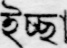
ইচ্ছা
